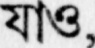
যাও,
